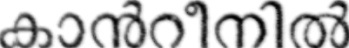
കാന്റീനില്‍
